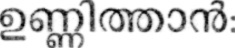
ഉണ്ണിത്താന്‍:
